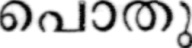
പൊതു
